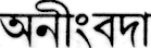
অনীংবদা
